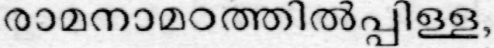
രാമനാമഠത്തില്‍പിള്ള,
